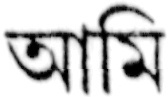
আমি
